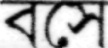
বসে
